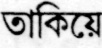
তাকিয়ে
